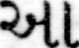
આ
